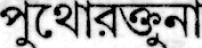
পুথোরক্তুনা
